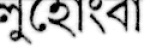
লুহোংবা
